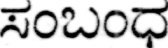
ಸಂಬಂಧ
